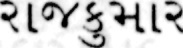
રાજકુમાર
